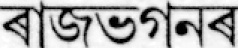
ৰাজভগনৰ
